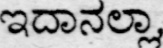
ಇದಾನಲ್ಲಾ,
